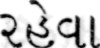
રહેવા
